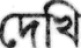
দেখি
